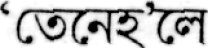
'তেনেহ'লে
